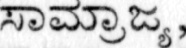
ಸಾಮ್ರಾಜ್ಯ,
